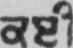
ਕਈ
